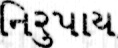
નિરુપાય
